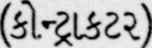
(કોન્ટ્રાકટર)
